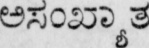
ಅಸಂಖ್ಯಾತ
